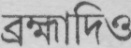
ব্ৰহ্মাদিও
